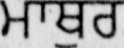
ਮਾਥੁਰ
